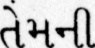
તેમની
